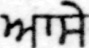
ਆਸੇ
